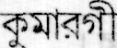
কুমারগী
